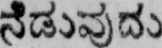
ನೆಡುವುದು
